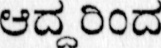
ಆದ್ದರಿಂದ
